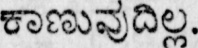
ಕಾಣುವುದಿಲ್ಲ.
